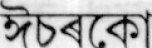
ঈচৰকো
